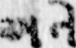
અને
